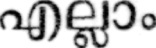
എല്ലാം
